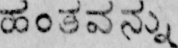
ಹಂತವನ್ನು
